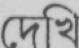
দেখি
